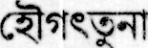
হৌগৎতুনা
